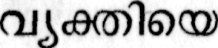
വ്യക്തിയെ
